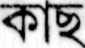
কাছ
